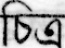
চিত্র
